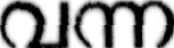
വന്ന
